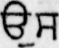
ਉਸ
